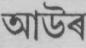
আউৰ
